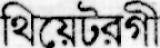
থিয়েটরগী
